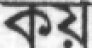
কয়
